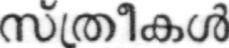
സ്ത്രീകള്‍
